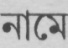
নামে
